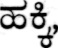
ಹಕ್ಕಿ,
